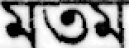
মতম
